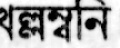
খল্লম্বনি
